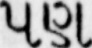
પણ
